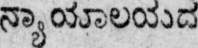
ನ್ಯಾಯಾಲಯದ
